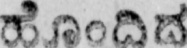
ಹೊಂದಿದ
